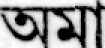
অমা
